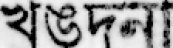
খঙদনা
